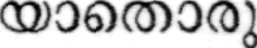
യാതൊരു
